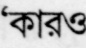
‘কারও
